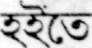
হইতে
